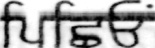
ਪਿਛਿਓਂ
